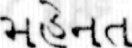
મહેનત
